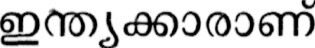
ഇന്ത്യക്കാരാണ്
